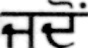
ਜਦੋਂ
